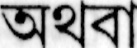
অথবা
